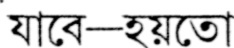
যাবে–হয়তো
